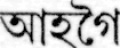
আহগৈ
